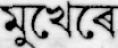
মুখেৰে
